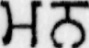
ਮਨ
